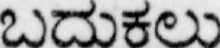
ಬದುಕಲು
